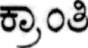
ಕ್ರಾಂತಿ
